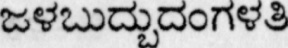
ಜಳಬುದ್ಬುದಂಗಳತಿ
